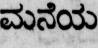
ಮನೆಯ
